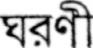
ঘরণী
